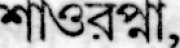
শাওরপ্না,
